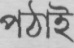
পঠাই
